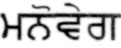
ਮਨੋਵੇਗ
